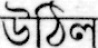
উঠিল
